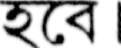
হবে।
